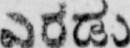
ಎರಡು
